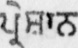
ਪ੍ਰੇਸ਼ਾਨ
